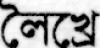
লৈখ্রে
